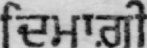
ਦਿਮਾਗ਼ੀ
